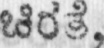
ಚಿರತೆ,
